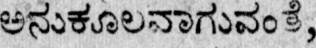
ಅನುಕೂಲವಾಗುವಂತೆ,
